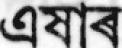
এষাৰ
